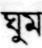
ঘুম
